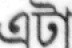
এটা
